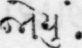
જોયું.
